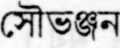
সৌভঞ্জন
